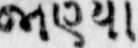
જાણ્યા
